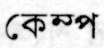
কেম্প
